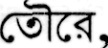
তৌরে,
